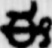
ಈ
